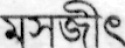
মসজীৎ
